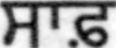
ਸਾਫ਼
